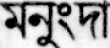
মনুংদা
